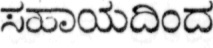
ಸಹಾಯದಿಂದ
